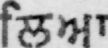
ਲਿਆ
